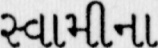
સ્વામીના
